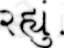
રહ્યું.
